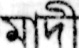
মাদী
